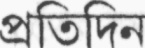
প্রতিদিন
